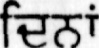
ਦਿਨਾਂ
